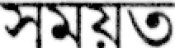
সময়ত
